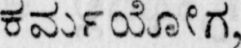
ಕರ್ಮಯೋಗ,
